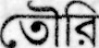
তৌরি
